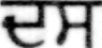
ਦਸ
